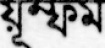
য়ূম্ফম
